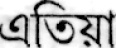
এতিয়া
